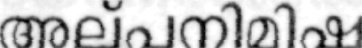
അല്പനിമിഷ
